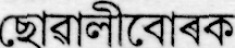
ছোৱালীবোৰক
